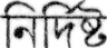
নিৰ্দিষ্ট
